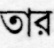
তার
